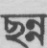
ছন্ন
